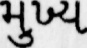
મુખ્ય
